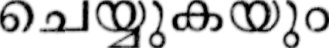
ചെയ്യുകയും
